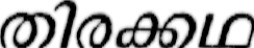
തിരക്കഥ
